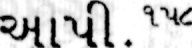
આપી.૧૫૮
